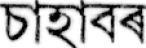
চাহাবৰ
